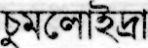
চুমলোইদ্রা
